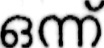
ഒന്ന്
